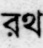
রথ
